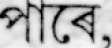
পাৰে,
